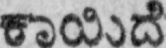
ಕಾಯಿದೆ
